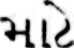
માટે
